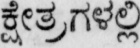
ಕ್ಷೇತ್ರಗಳಲ್ಲಿ
